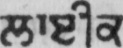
ਲਾਈਕ
